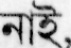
নাই,
